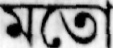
মতো
